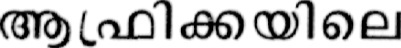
ആഫ്രിക്കയിലെ
